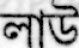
লাউ
